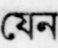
যেন
